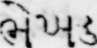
ભેખડ
